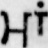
ਮਾਂ
